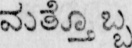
ಮತ್ತೊಬ್ಬ
